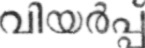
വിയര്‍പ്പ്
